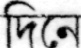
দিনে
